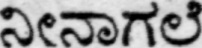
ನೀನಾಗಲೆ
